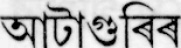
আটাগুৰিৰ
